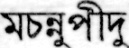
মচন্নুপীদু
